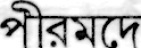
পীরমদে
